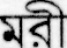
মরী
